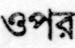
ওপর
